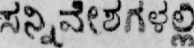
ಸನ್ನಿವೇಶಗಳಲ್ಲಿ
